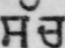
ਸੱਚ
